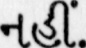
નહીં.
